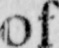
of
